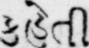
કહેતી
